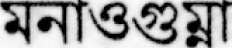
মনাওগুম্না
